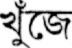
খুজেঁ
